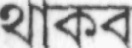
থাকব
